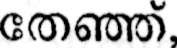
തേഞ്ഞ്,
